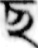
ছ
